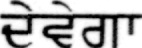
ਦੇਵੇਗਾ
